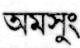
অমসুং
